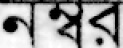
নম্বর
